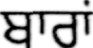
ਬਾਰਾਂ
